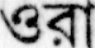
ওরা
